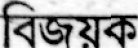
বিজয়ক
